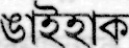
ঙাইহাক
